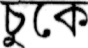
চুকে
